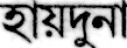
হায়দুনা
